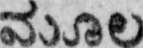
ಮೂಲ
